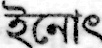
ইনোৎ
